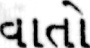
વાતો
